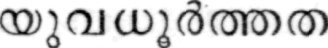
യുവധൂര്‍ത്തത
